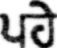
ਪਹੇ
